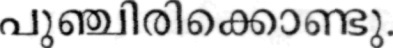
പുഞ്ചിരിക്കൊണ്ടു.
